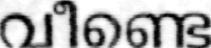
വീണ്ടെ
